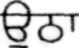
ਉਠਾ
